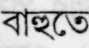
বাহুতে
